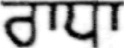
ਰਾਧਾ
